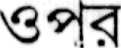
ওপর
